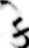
કે
